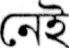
নেই
